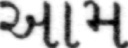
આમ
